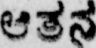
ಆತನ
